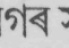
গৰ
